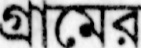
গ্রামের
